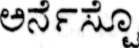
ಅರ್ನೆಸ್ಟೂ
